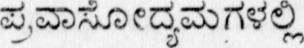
ಪ್ರವಾಸೋದ್ಯಮಗಳಲ್ಲಿ
